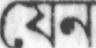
যেন
